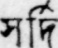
সর্দি
